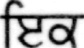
ਇਕ
